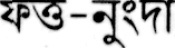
ফত্ত-নুংদা
